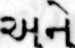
અને
